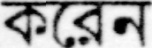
করেন
